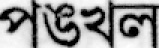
পঙখল
